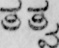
ತತ್ವ
